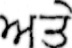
ਅਤੇ
